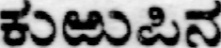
ಕುಱುಪಿನ
